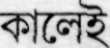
কালেই
